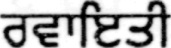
ਰਵਾਇਤੀ
